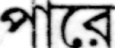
পারে
